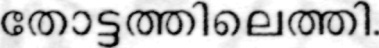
തോട്ടത്തിലെത്തി.
